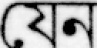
যেন
